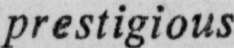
prestigious
